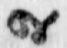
જ
